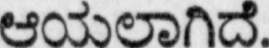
ಆಯಲಾಗಿದೆ.
